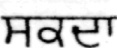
ਸਕਦਾ
